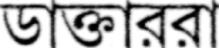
ডাক্তাররা
